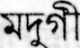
মদুগী
